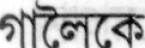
গালৈকে
